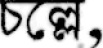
চল্লে,
